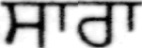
ਸਾਰਾ
